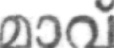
മാവ്
